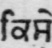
ਕਿਸੇ
